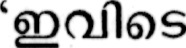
‘ഇവിടെ
